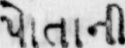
પોતાની
